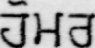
ਹੋਮਰ
